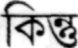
কিন্তু
